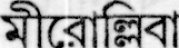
মীরোল্লিবা
